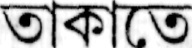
তাকাতে
